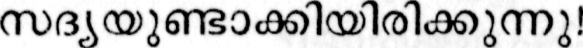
സദ്യയുണ്ടാക്കിയിരിക്കുന്നു!
